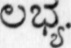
ಲಭ್ಯ.
